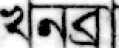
খনব্রা
